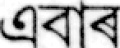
এবাৰ
